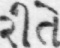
રીતે
